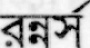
রন্নর্স
